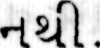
નથી.
